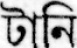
টানি
